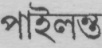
পাইলন্ত
